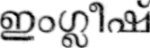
ഇംഗ്ലീഷ്
